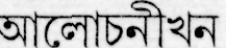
আলোচনীখন
